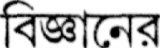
বিজ্ঞানের
